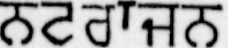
ਨਟਰਾਜਨ
